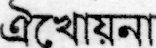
ঐখোয়না
